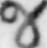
જ
